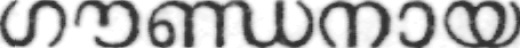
ഗൗണ്ഡനായ
